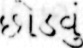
છોડવું
